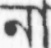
না
